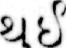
થઈ
